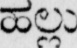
ಹಲ್ಲು
